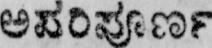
ಅಪರಿಪೂರ್ಣ
